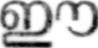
ഈ
